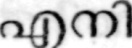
എനി
